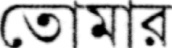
তোমার
